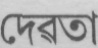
দেৱতা
